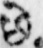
છે.
